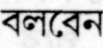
বলবেন
